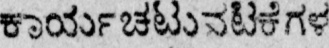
ಕಾರ್ಯಚಟುವಟಿಕೆಗಳ
